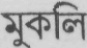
মুকলি
